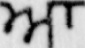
ਆ
